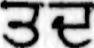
ਤਦ
